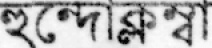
হুন্দোক্লম্বা
